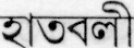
হাতবলী
